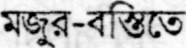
মজুর-বস্তিতে
